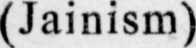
(Jainism)
